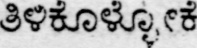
ತಿಳಿಕೊಳ್ಳೋಕೆ
